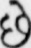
છે
